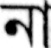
না
